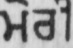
ਮੇਰੀ
